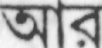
আর
